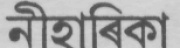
নীহাৰিকা
